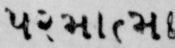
પરમાત્મા
